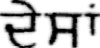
ਦੇਸਾਂ
